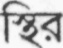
স্থির
